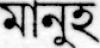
মানুহ
